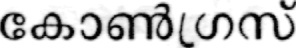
കോണ്‍ഗ്രസ്
